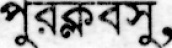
পুরক্লবসু,
